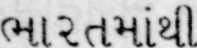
ભારતમાંથી
